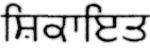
ਸ਼ਿਕਾਇਤ
